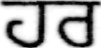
ਹਰ
